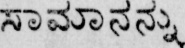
ಸಾಮಾನನ್ನು
